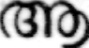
ആ
